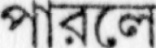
পারলে
